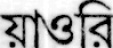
য়াওরি
